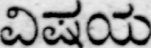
ವಿಷಯ
